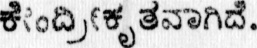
ಕೇಂದ್ರೀಕೃತವಾಗಿದೆ.
